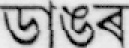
ডাঙৰ
